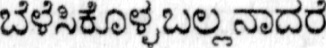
ಬೆಳೆಸಿಕೊಳ್ಳಬಲ್ಲನಾದರೆ
